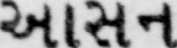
આસન
